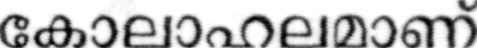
കോലാഹലമാണ്
